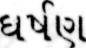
ઘર્ષણ
